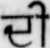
ਦੀ
